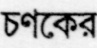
চণকের
